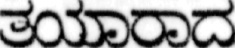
ತಯಾರಾದ
